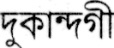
দুকান্দগী
